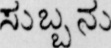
ಸುಬ್ಬನು
